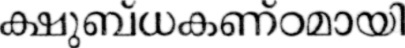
ക്ഷുബ്ധകണ്ഠമായി
